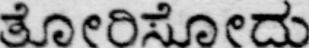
ತೋರಿಸೋದು
